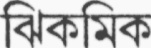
ঝিকমিক
